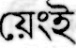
য়েংই
